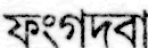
ফংগদবা
